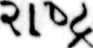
રાષ્ટ્ર
